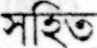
সহিত
